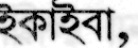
ইকাইবা,
